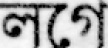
লগে
